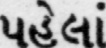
પહેલાં
